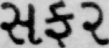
સફર
